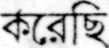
করেছি
